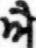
ਐ
